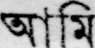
আমি
